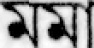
মমা
